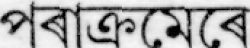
পৰাক্রমেৰে
